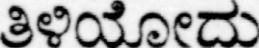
ತಿಳಿಯೋದು
